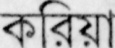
করিয়া
